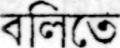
বলিতে
